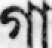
গা
